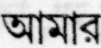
আমার
